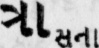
ત્રાસના
